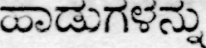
ಹಾಡುಗಳನ್ನು
